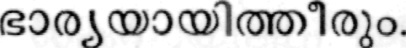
ഭാര്യയായിത്തീരും.
